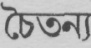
চৈতন্য
